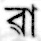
ৱা
